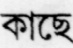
কাছে
